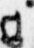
તું
